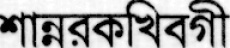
শান্নরকখিবগী
